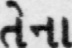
તેના
